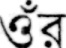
ওঁর
